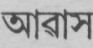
আৱাস
